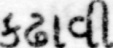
કઢાવી
